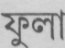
ফুলা
